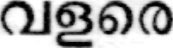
വളരെ
